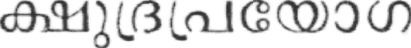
ക്ഷുദ്രപ്രയോഗ
